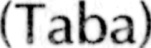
(Taba)
